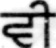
ਵੀ
